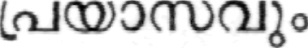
പ്രയാസവും
